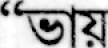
“ভায়
